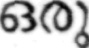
ഒരു
